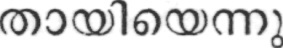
തായിയെന്നു
